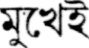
মুখেই
